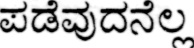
ಪಡೆವುದನೆಲ್ಲ
